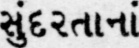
સુંદરતાનાં
